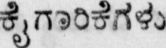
ಕೈಗಾರಿಕೆಗಳು
